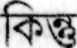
কিন্তু
